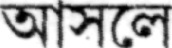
আসলে
